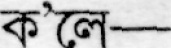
ক'লে-
